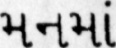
મનમાં
